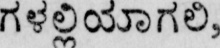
ಗಳಲ್ಲಿಯಾಗಲಿ,
